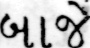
બાજે
